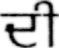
ਦੀ
